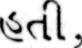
હતી,
